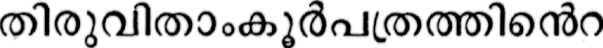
തിരുവിതാംകൂര്‍പത്രത്തിന്റെ
